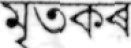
মৃতকৰ
